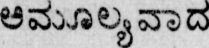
ಅಮೂಲ್ಯವಾದ
